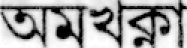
অমখক্না
